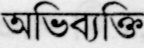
অভিব্যক্তি
